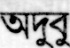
অদুবু
